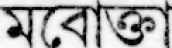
মবোক্তা
